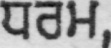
ਧਰਮ,
